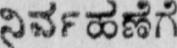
ನಿರ್ವಹಣೆಗೆ
